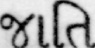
જાતિ
